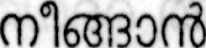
നീങ്ങാന്‍
